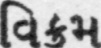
વિક્રમ
